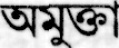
অমুক্তা
